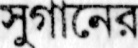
সুগানের
